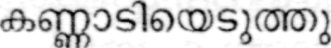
കണ്ണാടിയെടുത്തു
